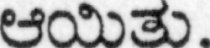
ಆಯಿತು.
